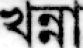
খন্না
